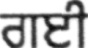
ਗਈ
